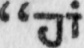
''ਹਾਂ
